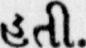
હતી.
